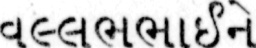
વલ્લભભાઈને
